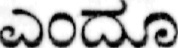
ಎಂದೂ
